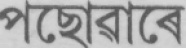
পছোৱাৰে
